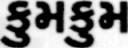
કુમકુમ
